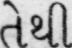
તેથી
